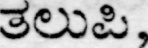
ತಲುಪಿ,
